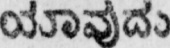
ಯಾವುದು
